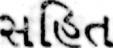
સહિત
